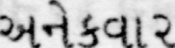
અનેકવાર
